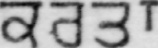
ਕਰਤਾ
